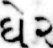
ઘેર
